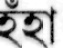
হঁহা
